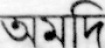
অমদি
